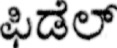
ಫಿಡೆಲ್
